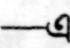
–এ
